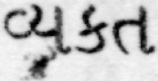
વ્યકત
